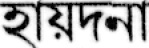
হায়দনা
